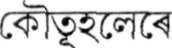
কৌতূহলেৰে
